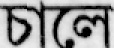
চালে
